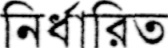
নির্ধারিত
